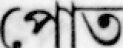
পোত
